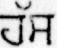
ਹੱਸ
